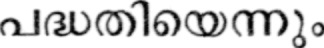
പദ്ധതിയെന്നും
